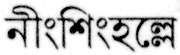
নীংশিংহল্লে
